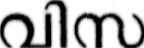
വിസ
